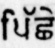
ਪਿੱਛੇ
